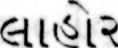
લાહોર
